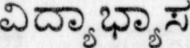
ವಿದ್ಯಾಭ್ಯಾಸ
